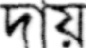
দায়
